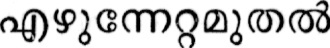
എഴുന്നേറ്റമുതല്‍
